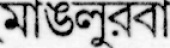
মাঙলুরবা
